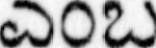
ಎಂಬ
